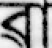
ৱা
